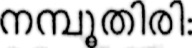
നമ്പൂതിരി:
